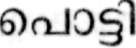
പൊട്ടി
